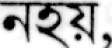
নহয়,
